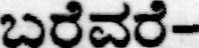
ಬರೆವರೆ-
